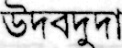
উদবদুদা
